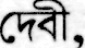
দেবী,
